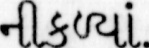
નીકળ્યાં.
